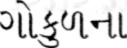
ગોકુળના
